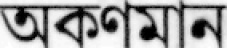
অকণমান
